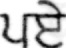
ਪਏ
